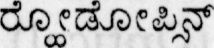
ರ್‍ಹೋಡೊಪ್ಸಿನ್
